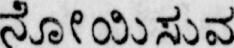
ನೋಯಿಸುವ
